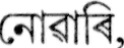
নোৱাৰি,
